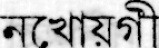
নখোয়গী
